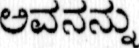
ಅವನನ್ನು
